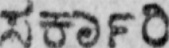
ಸರ್ಕಾರಿ
